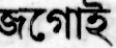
জগোই
